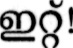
ഇറ്റ്!
